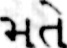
મતે
